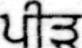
ਪੀੜ
